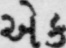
એક
